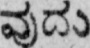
ವುದು
